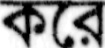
করে
